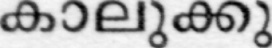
കാലുക്കു
